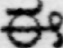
ಈ
